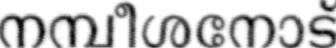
നമ്പീശനോട്
